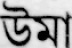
উমা
